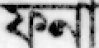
ফনা
